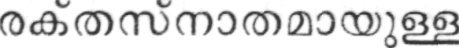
രക്തസ്നാതമായുള്ള
